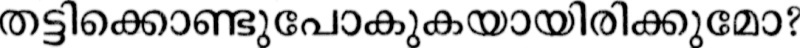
തട്ടിക്കൊണ്ടുപോകുകയായിരിക്കുമോ?
